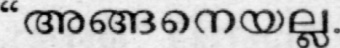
"അങ്ങനെയല്ല.
